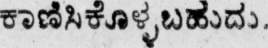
ಕಾಣಿಸಿಕೊಳ್ಳಬಹುದು.
